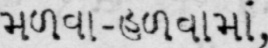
મળવા-હળવામાં,
